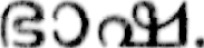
ഭാഷ.
